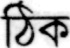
ঠিক
